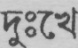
দুঃখে
